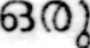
ഒരു
